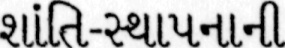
શાંતિ-સ્થાપનાની
